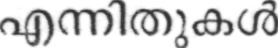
എന്നിതുകള്‍
